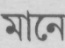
মানে
